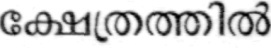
ക്ഷേത്രത്തില്‍
